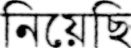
নিয়েছি
